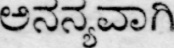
ಅನನ್ಯವಾಗಿ
